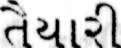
તૈયારી
